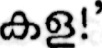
കള!’
